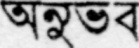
অনুভব
